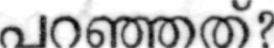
പറഞ്ഞത്?
